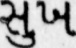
સુખ
